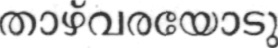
താഴ്വരയോടു
